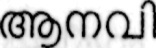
ആനവി
